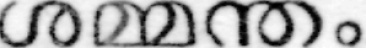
ശമ്മന്തം
